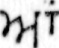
ਆਂ
